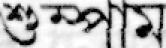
শুম্পাম
